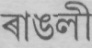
ৰাঙলী
